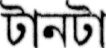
টানটা
